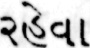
રહેવા
